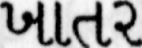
ખાતર
